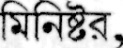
মিনিষ্টর,
